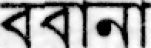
ববানা
